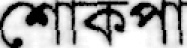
শোকপা
